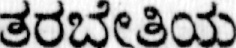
ತರಬೇತಿಯ
